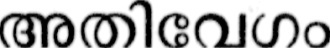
അതിവേഗം
